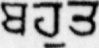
ਬਹੁਤ
